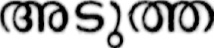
അടുത്ത
